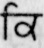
ਕਿ
